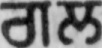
ਗਲ
